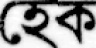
হেক
